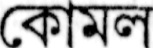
কোমল
